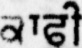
ਕਾਫੀ
